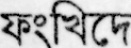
ফংখিদে
